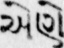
એણે
